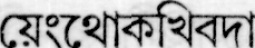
য়েংথোকখিবদা
